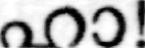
ഹാ!
